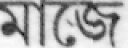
মাজে
